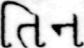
તિન
